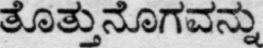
ತೊತ್ತುನೊಗವನ್ನು
